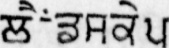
ਲੈਂਡਸਕੇਪ
